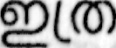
ഇത്ര
